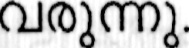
വരുന്നു.
